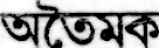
অতৈমক
